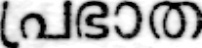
പ്രഭാത
